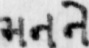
મનને
